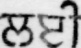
ਲਈ
